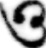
ও
